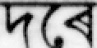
দৰে
